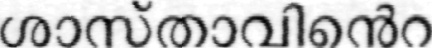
ശാസ്താവിന്റെ
